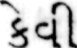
કેવી
